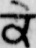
ਕੇ
